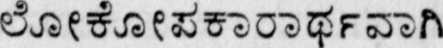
ಲೋಕೋಪಕಾರಾರ್ಥವಾಗಿ
